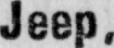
Jeep,
